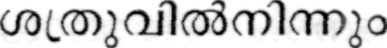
ശത്രുവില്‍നിന്നും
